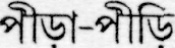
পীড়া-পীড়ি
